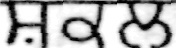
ਸ਼ਕਲ
